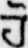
ਹੋ
